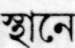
স্থানে
